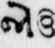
જોઉ
